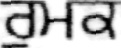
ਰੁਮਕ
